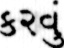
કરવું
